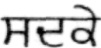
ਸਦਕੇ
